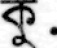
কু.
